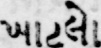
ખાટલો
